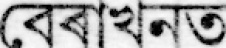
বেৰাখনত
